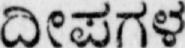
ದೀಪಗಳ
